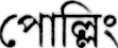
পোল্লিং
